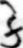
કે
